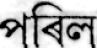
পৰিল
